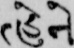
ત્હેને
